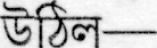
উঠিল-
